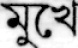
মুখে
